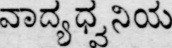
ವಾದ್ಯಧ್ವನಿಯ
